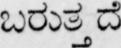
ಬರುತ್ತದೆ
